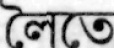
লৈতে
